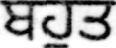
ਬਹੁਤ
